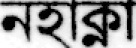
নহাক্না
